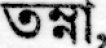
তম্না,
